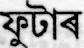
ফুটাৰ
